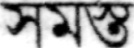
সমস্ত
